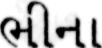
ભીના
